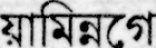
য়ামিন্নগে
